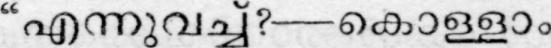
"എന്നുവച്ച്?-കൊള്ളാം
